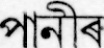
পানীৰ
